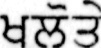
ਖਲੋਤੇ
